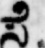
ಸೆ.
